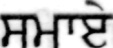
ਸਮਾਏ
